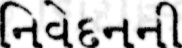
નિવેદનની
